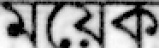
ময়েক
